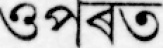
ওপৰত
